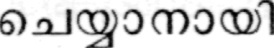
ചെയ്യാനായി
